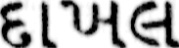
દાખલ
